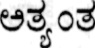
ಅತ್ಯಂತ
